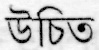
উচিত
